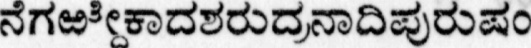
ನೆಗಱ್ದೇಕಾದಶರುದ್ರನಾದಿಪುರುಷಂ
